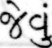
જેવું
